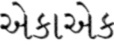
એકાએક
